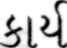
કાર્ય
